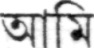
আমি
